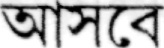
আসবে
